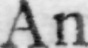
An
